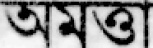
অমত্তা
